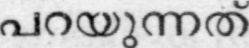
പറയുന്നത്
